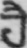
ਹੈ
